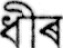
ধীৰ
